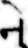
ને
